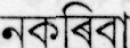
নকৰিবা
